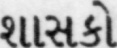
શાસકો
